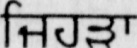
ਜਿਹੜਾ
